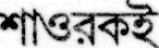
শাওরকই
